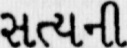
સત્યની
